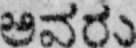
ಅವರು
